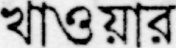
খাওয়ার
